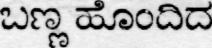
ಬಣ್ಣಹೊಂದಿದ
